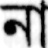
না
